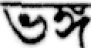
ভঙ্গ
